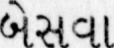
બેસવા
